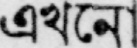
এখনো
